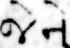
જેને
